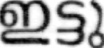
ഇട്ടു
